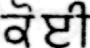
ਕੋਈ
